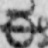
ಈ
